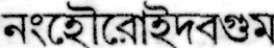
নংহৌরোইদবগুম
